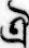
ঐ
